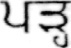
ਪੜ੍ਹ
